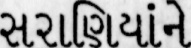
સરાણિયાંને
